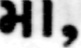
મા,
